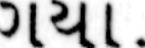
ગયા.
